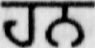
ਹਨ
